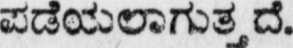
ಪಡೆಯಲಾಗುತ್ತದೆ.
